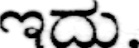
ಇದು.
